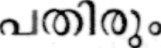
പതിരും
